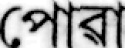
পোৱা
